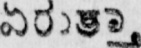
ಏರುತ್ತಾ
